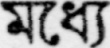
মধ্যে
